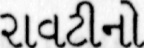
રાવટીનો
